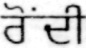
ਰੋਂਦੀ
